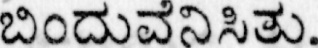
ಬಿಂದುವೆನಿಸಿತು.
